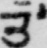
ਤੋਂ
